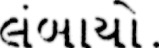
લંબાયો.
